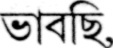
ভাবছি,
